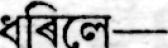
ধৰিলে-
